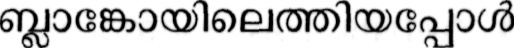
ബ്ലാങ്കോയിലെത്തിയപ്പോള്‍
